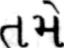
તમે
